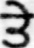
ਤੇ
